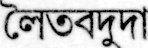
লৈতবদুদা
